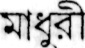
মাধুরী
